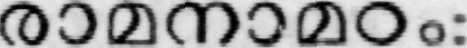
രാമനാമഠം:
